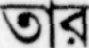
তার
